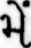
મેં
